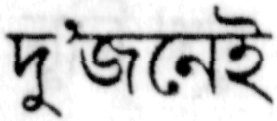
দু'জনেই
